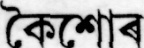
কৈশোৰ
